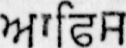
ਆਫਿਸ
